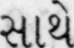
સાથે
